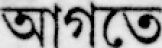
আগতে
